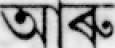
আৰু
